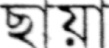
ছায়া
